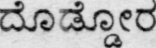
ದೊಡ್ಡೋರ
